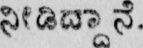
ನೀಡಿದ್ದಾನೆ.
